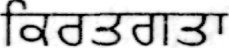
ਕਿਰਤਗਤਾ
